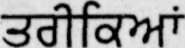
ਤਰੀਕਿਆਂ
